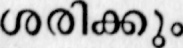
ശരിക്കും
